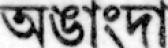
অঙাংদা
